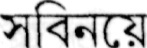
সবিনয়ে
